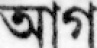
আগ
